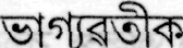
ভাগ্যৱতীক
